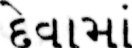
દેવામાં
